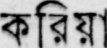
করিয়া
